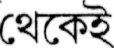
থেকেই
